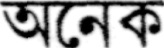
অনেক
